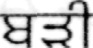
ਬੜੀ
